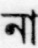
না
